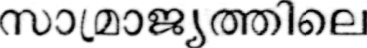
സാമ്രാജ്യത്തിലെ
